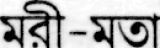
মরী-মতা
